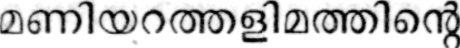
മണിയറത്തളിമത്തിന്റെ
